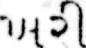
ખરી
